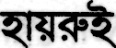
হায়রুই
